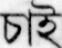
চাই
